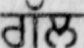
ਗੱਲ
